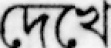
দেখে
